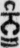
ਨੂੰ
